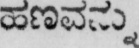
ಹಣವನ್ನು
